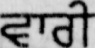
ਵਾਰੀ
